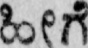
ಹೀಗೆ
